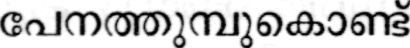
പേനത്തുമ്പുകൊണ്ട്
